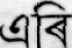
এৰি
